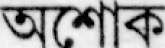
অশোক
